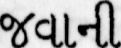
જવાની
